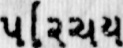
પરિચય
